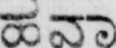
ಹವಾ
